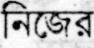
নিজের
